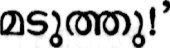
മടുത്തു!'
